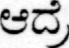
ಆದ್ರೆ
